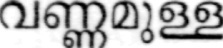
വണ്ണമുള്ള
